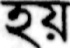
হয়
